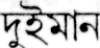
দুইমান
